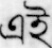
এই
